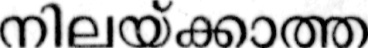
നിലയ്ക്കാത്ത
